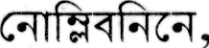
নোম্লিবনিনা,
